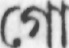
গো
